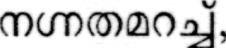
നഗ്നതമറച്ച്,
